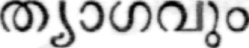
ത്യാഗവും
